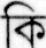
কি
